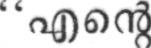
"എന്റെ
